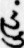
હું
